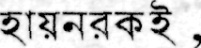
হায়নরকই,
